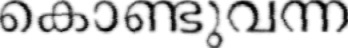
കൊണ്ടുവന്ന
